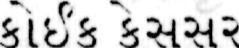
કોઈક
